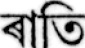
ৰাতি
